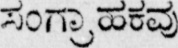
ಸಂಗ್ರಾಹಕವು
